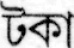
টকা
